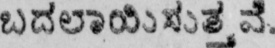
ಬದಲಾಯಿಸುತ್ತವೆ.
